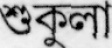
শুকুলা
